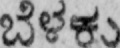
ಬೆಳಕು
